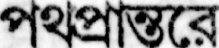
পথপ্রান্তরে
